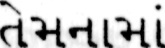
તેમનામાં
